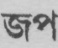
জপ
